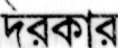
দরকার
